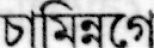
চামিন্নগে
